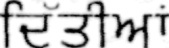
ਦਿੱਤੀਆਂ
